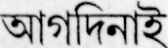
আগদিনাই
